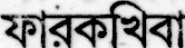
ফারকখিবা
